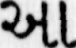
આ
